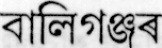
বালিগঞ্জৰ
